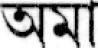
অমা
